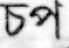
চপ
